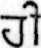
ਹੀ
